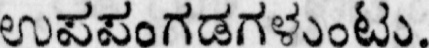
ಉಪಪಂಗಡಗಳುಂಟು.
